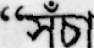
"সঁচা
